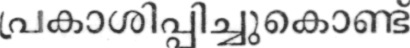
പ്രകാശിപ്പിച്ചുകൊണ്ട്
